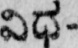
ವಿಧ-
